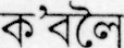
ক'বলৈ
